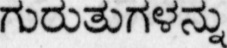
ಗುರುತುಗಳನ್ನು
